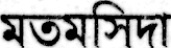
মতমসিদা
